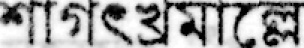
শাগৎখ্রমাল্লে
